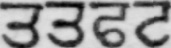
ਤਤਫਟ
